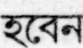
হবেন
